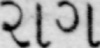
રાગ
